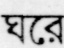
ঘরে
